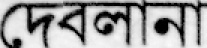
দেবলানা
